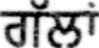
ਗੱਲਾਂ
